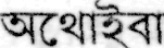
অথোইবা
